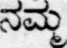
ನಮ್ಮ
